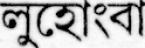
লুহোংবা
